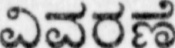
ವಿವರಣೆ
